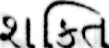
શક્તિ
